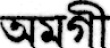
অমগী
